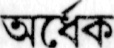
অর্ধেক
